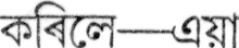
কৰিলে-এয়া
